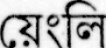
য়েংলি
